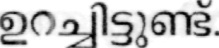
ഉറച്ചിട്ടുണ്ട്.
